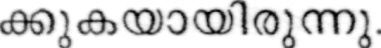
ക്കുകയായിരുന്നു.
